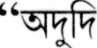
“অদুদি
